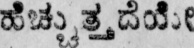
ಹೆಚ್ಚುತ್ತದೆಯೇ
